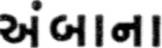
અંબાના
